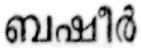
ബഷീര്‍
